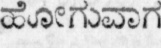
ಹೋಗುವಾಗ
